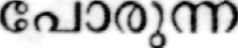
പോരുന്ന
